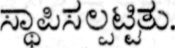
ಸ್ಥಾಪಿಸಲ್ಪಟ್ಟಿತು.
